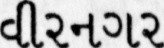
વીરનગર
